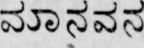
ಮಾನವನ
